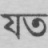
যত
